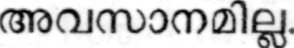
അവസാനമില്ല.
